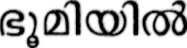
ഭൂമിയില്‍
